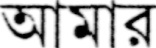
আমার
